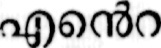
എന്റെ
